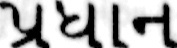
પ્રધાન
